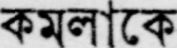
কমলাকে
